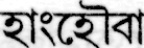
হাংহৌবা
